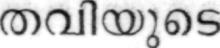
തവിയുടെ
